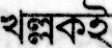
খল্লকই
